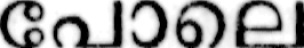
പോലെ
